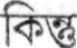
কিন্তু
